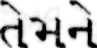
તેમને
